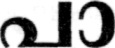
പാ
